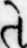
તે
